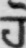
ਹੋ
